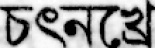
চৎনখ্রে
